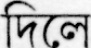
দিলে
